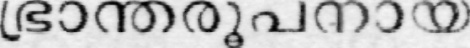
ഭ്രാന്തരൂപനായ
